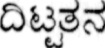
ದಿಟ್ಟತನ
